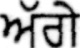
ਅੱਗੇ
